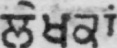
ਲੇਖਕਾਂ
